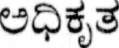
ಅಧಿಕೃತ
